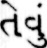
તેવું
